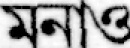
মনাও
